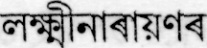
লক্ষ্মীনাৰায়ণৰ
